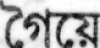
গৈয়ে
